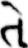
તે
